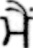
ਮੈਂ
